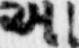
આ
